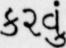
કરવું
